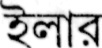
ইলার
